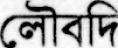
লৌবদি
